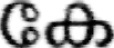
കേ
